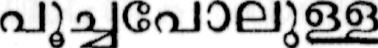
പൂച്ചപോലുള്ള
